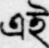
এই
